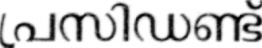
പ്രസിഡണ്ട്
